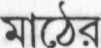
মাঠের
